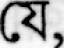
যে,
